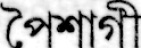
পৈশাগী
